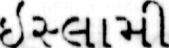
ઇસ્લામી
